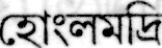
হোংলমদ্রি
